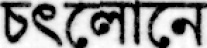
চৎলোনে
